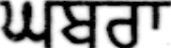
ਘਬਰਾ
